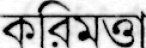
করিমত্তা
